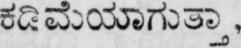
ಕಡಿಮೆಯಾಗುತ್ತಾ,
